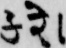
કરો
